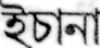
ইচানা
